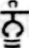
ਨੂੰ
